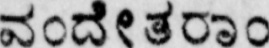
ವಂದೇತರಾಂ
